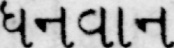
ધનવાન
